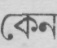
কেন
